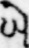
બે
